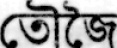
তৌজৈ
